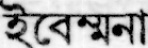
ইবেম্মনা
